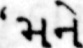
'મને
